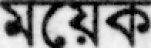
ময়েক
